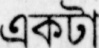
একটা
